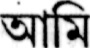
আমি
